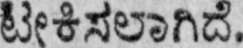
ಟೀಕಿಸಲಾಗಿದೆ.
